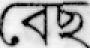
বেছ
